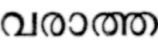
വരാത്ത
